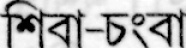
শিবা-চংবা
